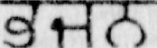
ਭਜਨ
